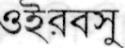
ওইরবসু
